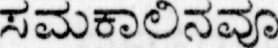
ಸಮಕಾಲಿನವೂ
